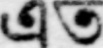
এত
